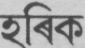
হৰিক
